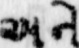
અને
